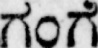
ಗಂಗೆ
